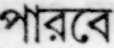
পারবে
